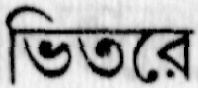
ভিতরে
